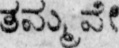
ತಮ್ಮವೇ
